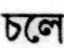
চলে
